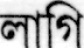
লাগি
